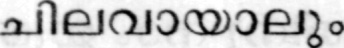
ചിലവായാലും
